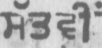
ਸੱਤਵੀਂ
